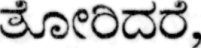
ತೋರಿದರೆ,
